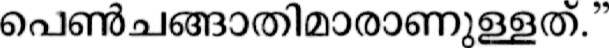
പെണ്‍ചങ്ങാതിമാരാണുള്ളത്.”
